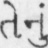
તેનું
